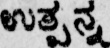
ಉತ್ಪನ್ನ
